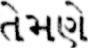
તેમણે
